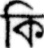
কি
